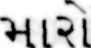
મારો
